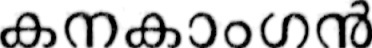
കനകാംഗന്‍
